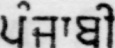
ਪੰਜਾਬੀ
